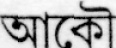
আকৌ
